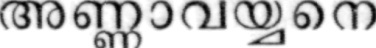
അണ്ണാവയ്യനെ
